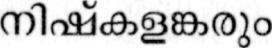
നിഷ്കളങ്കരും
